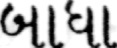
બાધા
